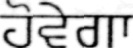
ਹੋਵੇਗਾ
